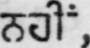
ਨਹੀਂ,
